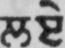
ਲਏ
